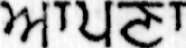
ਆਪਣਾ
